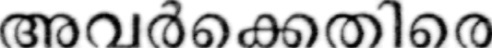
അവര്‍ക്കെതിരെ
